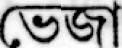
ভেজা
